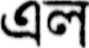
এল
